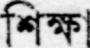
শিক্ষা
